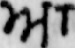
ਆ
